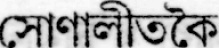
সোণালীতকৈ
